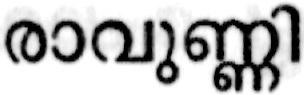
രാവുണ്ണി
